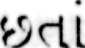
છતાં
